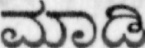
ಮಾಡಿ
